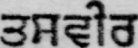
ਤਸਵੀਰ
